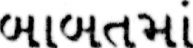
બાબતમાં
